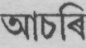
আচৰি
